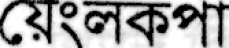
য়েংলকপা
